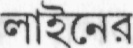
লাইনের
